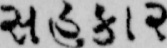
સહકાર
